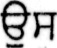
ਉਸ
